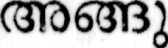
അങ്ങു
